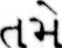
તમે
